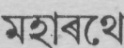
মহাৰথে
